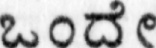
ಒಂದೇ
